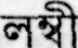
লম্বী
